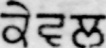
ਕੇਵਲ
